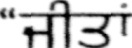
''ਜੀਤਾਂ
